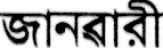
জানৱারী
